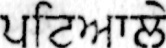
ਪਟਿਆਲੇ
